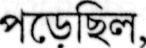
পড়েছিল,
